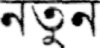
নতুন
